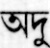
অদু
